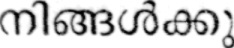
നിങ്ങള്‍ക്കു
